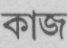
কাজ
